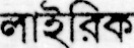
লাইরিক
